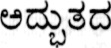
ಅದ್ಭುತದ
